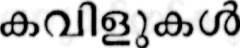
കവിളുകള്‍
